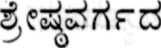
ಶ್ರೇಷ್ಠವರ್ಗದ
